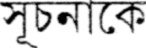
সূচনাকে
